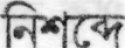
নিশব্দে
